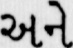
અને
